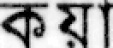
কয়া
